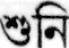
শুনি
